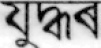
যুদ্ধৰ
